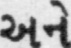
અને
